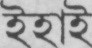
ইহাই
